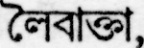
লৈবাক্তা,
